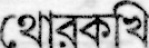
থোরকখি
